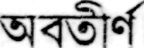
অবতীর্ণ
